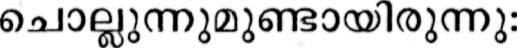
ചൊല്ലുന്നുമുണ്ടായിരുന്നു:
